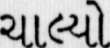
ચાલ્યો
